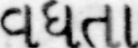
વધતા
